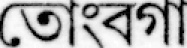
তোংবগা
